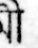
মী
